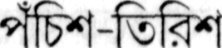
পঁচিশ-তিরিশ
